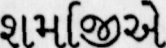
શર્માજીએ
